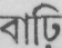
বাঢ়ি
